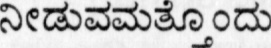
ನೀಡುವಮತ್ತೊಂದು
